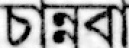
চান্নবা
